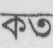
কত
